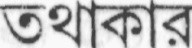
তথাকার
